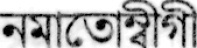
নমাতোম্বীগী
